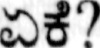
ಏಕೆ?
